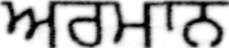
ਅਰਮਾਨ
